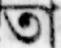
,তা
